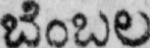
ಬೆಂಬಲ
